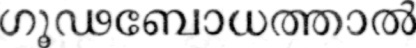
ഗൂഢബോധത്താല്‍
